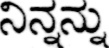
ನಿನ್ನನ್ನು
